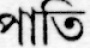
পাতি
